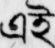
এই
